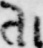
તો
